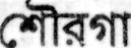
শৌরগা
